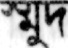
স্মুদ
